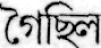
গৈছিল
